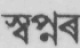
স্বপ্নৰ
